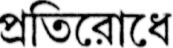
প্রতিরোধে
